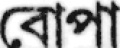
বোপা
